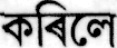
কৰিলে
